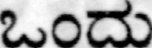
ಒಂದು
